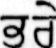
ਭਰੇ
